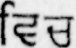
ਵਿਚ
